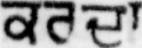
ਕਰਦਾ
